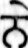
ਨੇ
